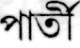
পার্তী
